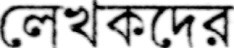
লেখকদের
